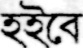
হইবে
